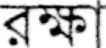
রক্ষা
